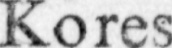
Kores
